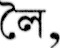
লৈ,
